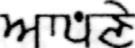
ਆਪਣੇ
